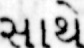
સાથે
